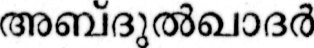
അബ്ദുല്‍ഖാദര്‍
